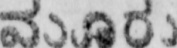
ಮೂರು
